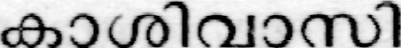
കാശിവാസി
